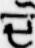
ਦੋ
